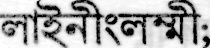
লাইনীংলম্মী;
